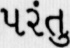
પરંતુ
